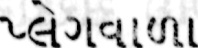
પ્લેગવાળા
